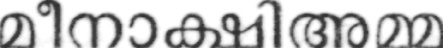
മീനാക്ഷിഅമ്മ
